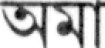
অমা
